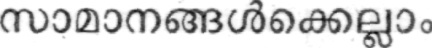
സാമാനങ്ങള്‍ക്കെല്ലാം
